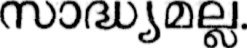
സാദ്ധ്യമല്ല.
